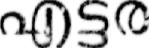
എട്ടര
